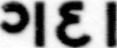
ગદા
